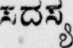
ಸದಸ್ಯ
